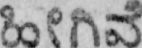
ಹೀಗಿವೆ
